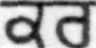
ਕਰ
